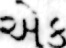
એક
